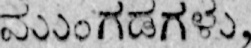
ಮುಂಗಡಗಳು,
